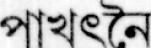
পাখৎনৈ
